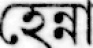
হেন্না
